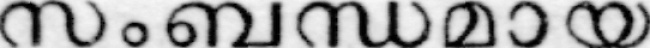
സംബന്ധമായ
